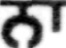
ਨਾ
